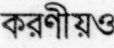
করণীয়ও
